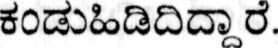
ಕಂಡುಹಿಡಿದಿದ್ದಾರೆ.
